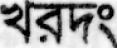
খরদং
